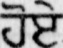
ਹੋਏ
